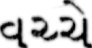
વચ્ચે
